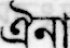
ঐনা
